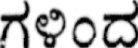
ಗಳಿಂದ
